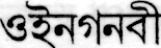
ওইনগনবী
